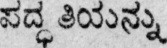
ಪದ್ಧತಿಯನ್ನು
